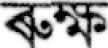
ৰুক্ষ
